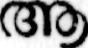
ആ
